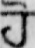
ਹੋ
